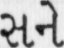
સને
